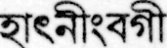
হাৎনীংবগী
